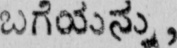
ಬಗೆಯನ್ನು,
